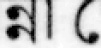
চান্না
